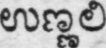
ಉಣ್ಣಲಿ
